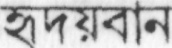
হৃদয়বান
